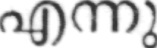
എന്നു
